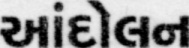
આંદોલન
